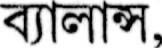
ব্যালান্স,
